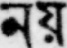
নয়
